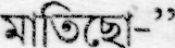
মাতিছো-"
